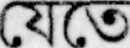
যেতে
